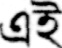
এই
